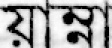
য়াম্না
